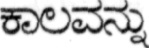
ಕಾಲವನ್ನು
